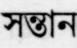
সন্তান
